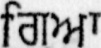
ਗਿਆ
